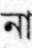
না
